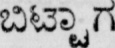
ಬಿಟ್ಟಾಗ
